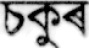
চকুৰ
